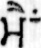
ਮੈਂ
